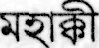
মহাক্কী
